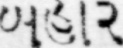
બહાર
